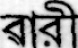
ৱারী
